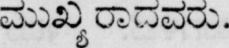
ಮುಖ್ಯರಾದವರು.
